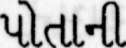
પોતાની
